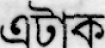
এটাক
